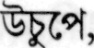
উচুপে,
